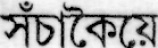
সঁচাকৈয়ে
